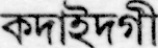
কদাইদগী
